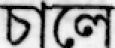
চালে
